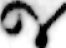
જ
